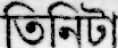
তিনিটা
